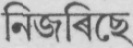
নিজৰিছে
